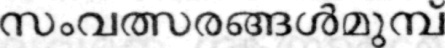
സംവത്സരങ്ങള്‍മുമ്പ്
